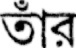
তাঁর
